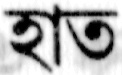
হাত
